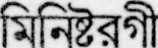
মিনিষ্টরগী
